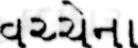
વચ્ચેના
